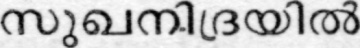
സുഖനിദ്രയില്‍
